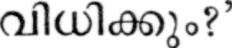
വിധിക്കും?'
